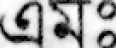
এমঃ
